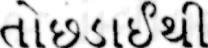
તોછડાઈથી
